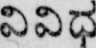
ವಿವಿಧ
